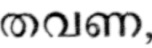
തവണ,
